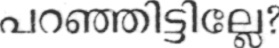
പറഞ്ഞിട്ടില്ലേ?
